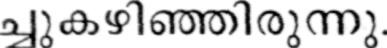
ച്ചുകഴിഞ്ഞിരുന്നു.
